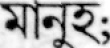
মানুহ;
